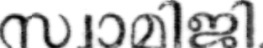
സ്വാമിജി.
